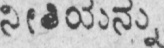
ನೀತಿಯನ್ನು
